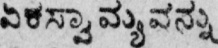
ಏಕಸ್ವಾಮ್ಯವನ್ನು
